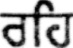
ਰਹਿ
